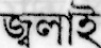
জ্বলাই
